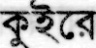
কুইরে
